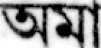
অমা
